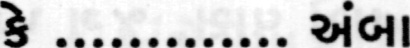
કે.....અંબા
